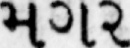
મગર
